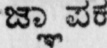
ಜ್ಞಾಪಕ
